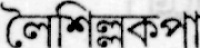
লৈশিল্লকপা
